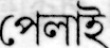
পেলাই
